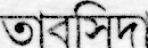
তাবসিদা
